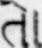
તો
